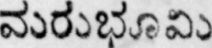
ಮರುಭೂಮಿ
